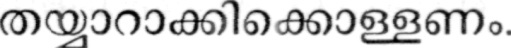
തയ്യാറാക്കിക്കൊള്ളണം.
